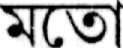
মতো
